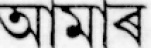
আমাৰ
